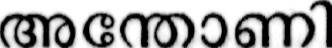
അന്തോണി
